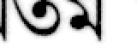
মতম
